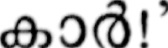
കാര്‍!'
